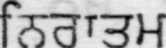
ਨਿਰਾਤਮ
